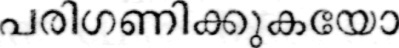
പരിഗണിക്കുകയോ
